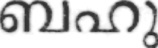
ബഹു
